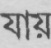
যায়
